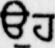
ਉਹ
